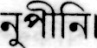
নুপীনি।
